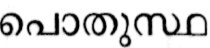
പൊതുസ്ഥ
